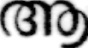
ആ
